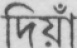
দিয়াঁ
